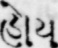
હોય
